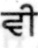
ਵੀ
